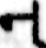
ન
